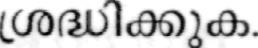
ശ്രദ്ധിക്കുക.
